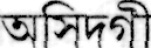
অসিদগী
